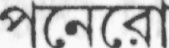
পনেরো
